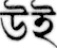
উই
